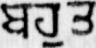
ਬਹੁਤ
